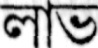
লাভ
